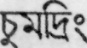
চুমদ্রিং
